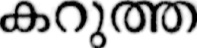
കറുത്ത
